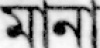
মানা
